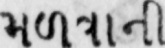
મળવાની
